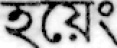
হয়েং
